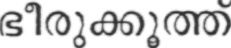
ഭീരുക്കൂത്ത്
